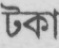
টকা
